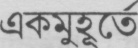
একমুহূর্তে
